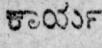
ಕಾರ್ಯ
